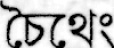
চৈথেং
